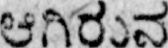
ಆಗಿರುವ
